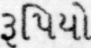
રૂપિયો
